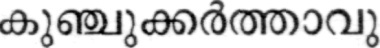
കുഞ്ചുക്കര്‍ത്താവു
